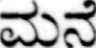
ಮನೆ
